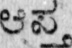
ಆಪ್ತ
